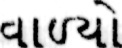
વાળ્યો
